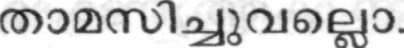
താമസിച്ചുവല്ലൊ.
